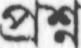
প্রশ্ন
